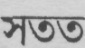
সতত
